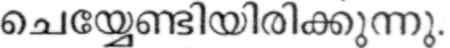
ചെയ്യേണ്ടിയിരിക്കുന്നു.
